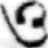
ও
